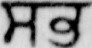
ਸਭ
